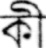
কী
